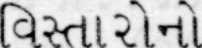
વિસ્તારોનો
